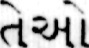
તેઓ
